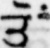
ਤੋਂ
